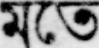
মতে
